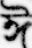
ঈ
